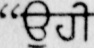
''ਉਹੀ
